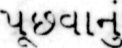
પૂછવાનું
